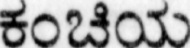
ಕಂಚಿಯ
